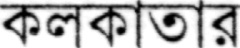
কলকাতার
